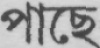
পাছে
